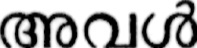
അവള്‍
